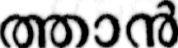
ത്താന്‍
